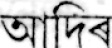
আদিৰ
